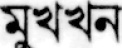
মুখখন
